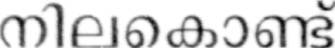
നിലകൊണ്ട്
